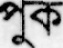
পুক
